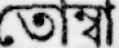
তোম্বা
